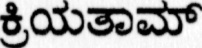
ಕ್ರಿಯತಾಮ್
